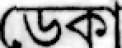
ডেকা
